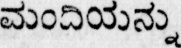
ಮಂದಿಯನ್ನು
